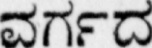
ವರ್ಗದ
